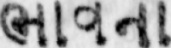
ભાવના
